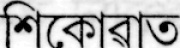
শিকোৱাত
